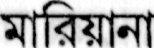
মারিয়ানা
